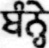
ਬੰਨ੍ਹੇ
